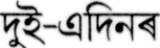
দুই-এদিনৰ
